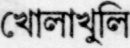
খোলাখুলি
